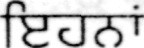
ਇਹਨਾਂ
